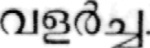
വളര്‍ച്ച.
